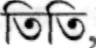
তিতি,
